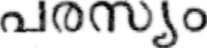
പരസ്യം
